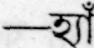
–হ্যাঁ
